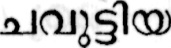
ചവുട്ടിയ
